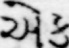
એક
